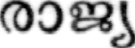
രാജ്യ
